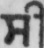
ਸੀ
